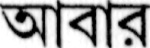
আবার
